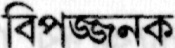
বিপজ্জনক
